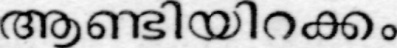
ആണ്ടിയിറക്കം
